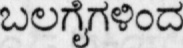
ಬಲಗೈಗಳಿಂದ
